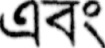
এবং
